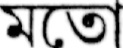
মতো
